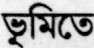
ভূমিতে
